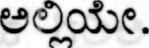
ಅಲ್ಲಿಯೇ.
